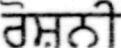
ਰੋਸ਼ਨੀ
